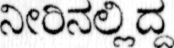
ನೀರಿನಲ್ಲಿದ್ದ
